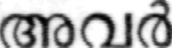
അവര്‍
